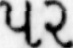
પર
